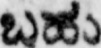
ಬಹು
